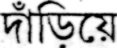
দাঁড়িয়ে
